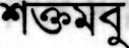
শক্তমবু
